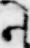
ને
